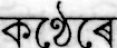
কণ্ঠেৰে
